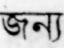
জন্য
